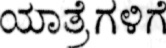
ಯಾತ್ರೆಗಳಿಗೆ
